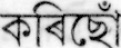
কৰিছোঁ
